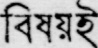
বিষয়ই
